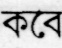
কবে
